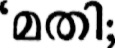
‘മതി;
